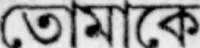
তোমাকে
